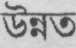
উন্নত
